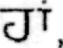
ਹਾਂ,
